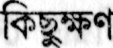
কিছুক্ষণ
